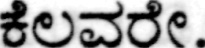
ಕೆಲವರೇ.
